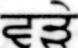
ਵੜੇ
